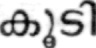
കൂടി
